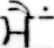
ਮੈਂ
